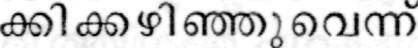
ക്കിക്കഴിഞ്ഞുവെന്ന്
